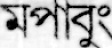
মপাবুং
